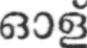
ഓള്
